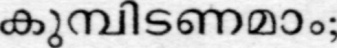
കുമ്പിടണമാം;
